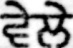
ਵੇਲੇ
